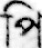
পি
